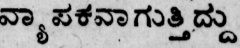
ವ್ಯಾಪಕವಾಗುತ್ತಿದ್ದು
